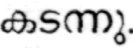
കടന്നു.
